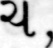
ચ,
